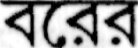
বরের
